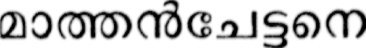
മാത്തന്‍ചേട്ടനെ
